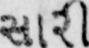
સારી
